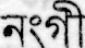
নংগী
